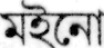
মইনো
